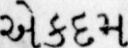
એકદમ
